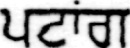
ਪਟਾਂਗ
